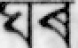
ঘৰ
